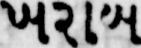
ખરાબ
